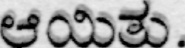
ಆಯಿತು.
